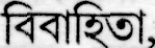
বিবাহিতা,
